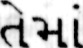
તેમાં
